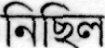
নিছিল
